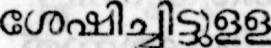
ശേഷിച്ചിട്ടുള്ള
